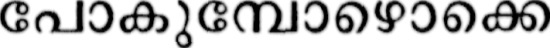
പോകുമ്പോഴൊക്കെ
